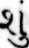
શું
